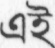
এই
